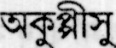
অকুপ্পীসু
